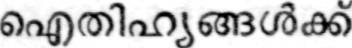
ഐതിഹ്യങ്ങള്‍ക്ക്
